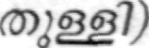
തുള്ളി)
